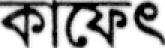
কাফেৎ
